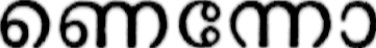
ണെന്നോ
